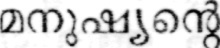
മനുഷ്യന്റെ
